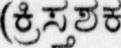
(ಕ್ರಿಸ್ತಶಕ
